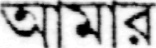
আমার
